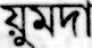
য়ুমদা
